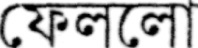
ফেললো
